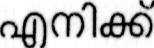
എനിക്ക്
